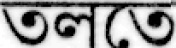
তলতে
